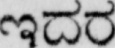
ಇದರ
